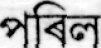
পৰিল
